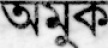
অমুক
